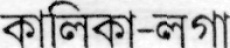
কালিকা-লগা
